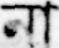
না
